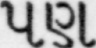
પણ
